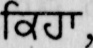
ਕਿਹਾ,
